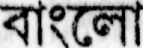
বাংলো
